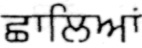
ਛਾਲਿਆਂ
